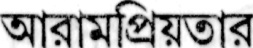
আরামপ্রিয়তার
